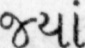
જ્યાં
